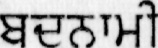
ਬਦਨਾਮੀ
